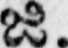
ಜಿ.
